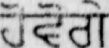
ਹੋਵੋਗੇ
